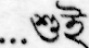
...শুই
